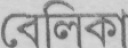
বেলিকা
